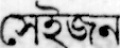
সেইজন
